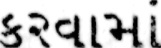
કરવામાં
